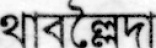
থাবল্লৈদা
